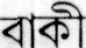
বাকী
